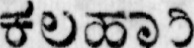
ಕಲಹಾರಿ
